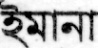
ইমানা
